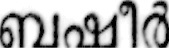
ബഷീര്‍
